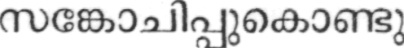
സങ്കോചിപ്പുകൊണ്ടു
